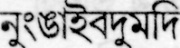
নুংঙাইবদুমদি
